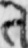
તે
